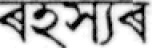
ৰহস্যৰ
